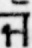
ਜੋ
